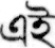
এই
